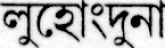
লুহোংদুনা
